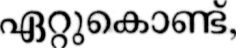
ഏറ്റുകൊണ്ട്,
